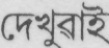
দেখুৱাই
